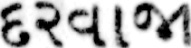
દરવાજા
